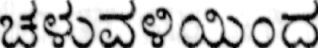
ಚಳುವಳಿಯಿಂದ
